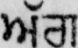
ਅੱਗ
